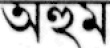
অহুম
